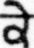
ਕੇ
